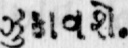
ઝુકાવશે.
